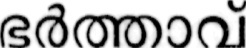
ഭര്‍ത്താവ്
